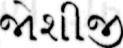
જોશીજી
